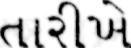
તારીખે
